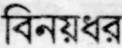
বিনয়ধর
